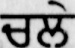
ਚਲੇ
